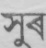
সুৰ
